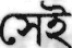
সেই
